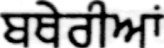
ਬਥੇਰੀਆਂ
